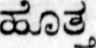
ಹೊತ್ತ
